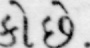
કોછે.
